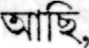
আছি,
